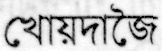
খোয়দাজৈ
